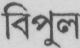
বিপুল
